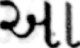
આ
